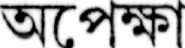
অপেক্ষা
